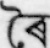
ৰৈ
